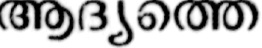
ആദ്യത്തെ
